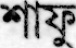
শাফু
